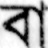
বা
